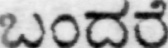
ಬಂದರೆ
